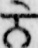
ਨੇ
